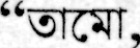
“তামো,
